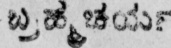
ಬ್ರಹ್ಮಚರ್ಯ
